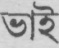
ভাই
